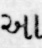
આ
